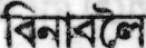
বিনাবলৈ
